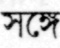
সঙ্গে
